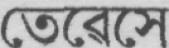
তেৱেসে
